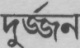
দুৰ্জ্জন
